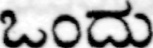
ಒಂದು
